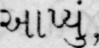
આપ્યું,
